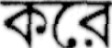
করে
